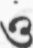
ও
